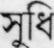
সুধি
